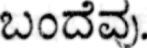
ಬಂದೆವು.
